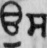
ਉਸ
